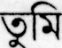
তুমি
